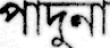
পাদুনা
